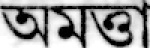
অমত্তা
